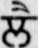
ਲੈ
